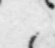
ભેદ
